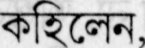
কহিলেন,
